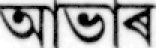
আভাৰ
